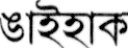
হাইহাক
